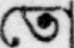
তো
